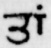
ਤਾਂ
